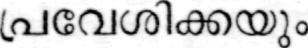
പ്രവേശിക്കയും
